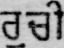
ਰੁਚੀ
